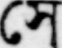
সে
